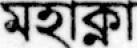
মহাক্না
